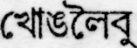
খোঙলৈবু
